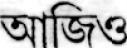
আজিও
